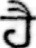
ਹੈ
